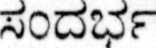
ಸಂದರ್ಭ
